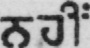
ਨਹੀਂ
